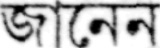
জানেন
